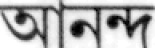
আনন্দ
